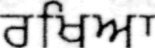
ਰਖਿਆ
